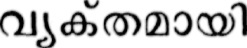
വ്യക്തമായി
